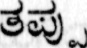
ತಪ್ಪು
